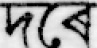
দৰে
